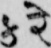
કરે
